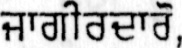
ਜਾਗੀਰਦਾਰੋ,
